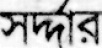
সর্দ্দার
